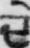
ਦੇ
